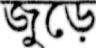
জুড়ে
